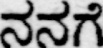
ನನಗೆ
